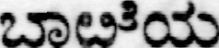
ಬಾೞೆಯ
